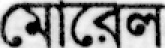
মোরেল
